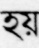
হয়
